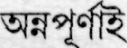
অন্নপূৰ্ণাই
